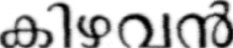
കിഴവന്‍
